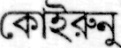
কোইরুনু
